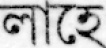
লাহে
